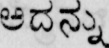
ಅದನ್ನು
